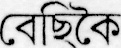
বেছিকৈ
